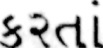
કરતાં
